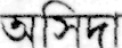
অসিদা
